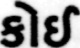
કોઈ
